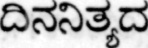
ದಿನನಿತ್ಯದ
